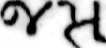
જ્પ્ત
